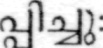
പ്പിച്ചു:
